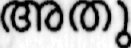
അതു
